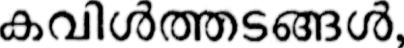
കവിള്‍ത്തടങ്ങള്‍,
